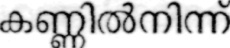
കണ്ണില്‍നിന്ന്
